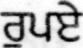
ਰੁਪਏ
